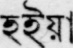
হইয়া
